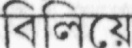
বিলিয়ে
